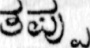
ತಪ್ಪು
